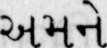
અમને
